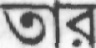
তার
